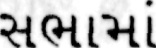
સભામાં
